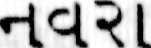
નવરા
